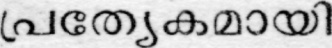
പ്രത്യേകമായി
